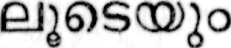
ലൂടെയും
